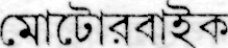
মোটোরবাইক
